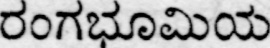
ರಂಗಭೂಮಿಯ
